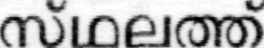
സ്ഥലത്ത്
